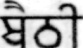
ਬੈਠੀ
